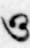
ও
